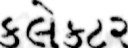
કલેક્ટર
